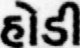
હોડી
